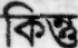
কিন্তু
